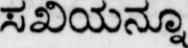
ಸಖಿಯನ್ನೂ
